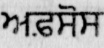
ਅਫ਼ਸੋਸ
